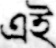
এই
